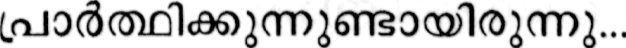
പ്രാര്‍ത്ഥിക്കുന്നുണ്ടായിരുന്നു...
